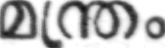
മന്ത്രം
